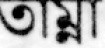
তাম্না
